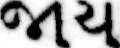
જાય
